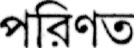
পরিণত
